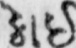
કોઈ
